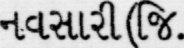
નવસારી(જિ.
